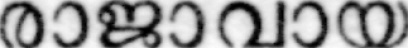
രാജാവായ
